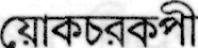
য়োকচরকপী
